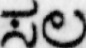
ಸಲ
